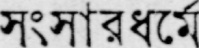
সংসারধর্মে
